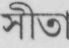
সীতা
